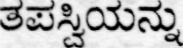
ತಪಸ್ವಿಯನ್ನು
